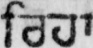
ਰਿਹਾ
